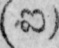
(ಐ)
